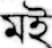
মই
